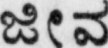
ಜೀವ
